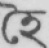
হৈ
